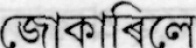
জোকাৰিলে
